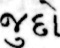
જુદો
